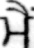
ਮੈਂ
